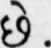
છે.
